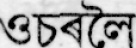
ওচৰলৈ
